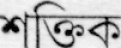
শক্তিক
